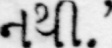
નથી.'
